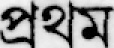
প্রথম
